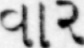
વાર
